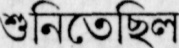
শুনিতেছিল
